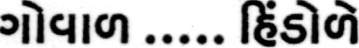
ગોવાળ.....હિંડોળે
